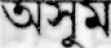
অসুম
